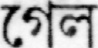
গেল
